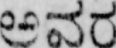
ಅವರ
